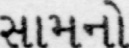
સામનો
